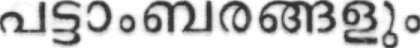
പട്ടാംബരങ്ങളും
